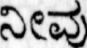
ನೀವು
